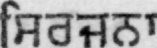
ਸਿਰਜਨਾ
